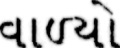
વાળ્યો
